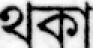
থকা
